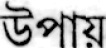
উপায়
